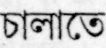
চালাতে
